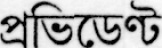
প্ৰভিডেণ্ট
